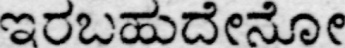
ಇರಬಹುದೇನೋ
